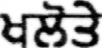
ਖਲੋਤੇ
